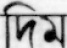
দিম
